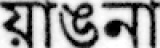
য়াঙনা
